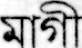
মাগী
